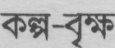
কল্প-বৃক্ষ
